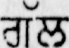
ਗੱਲ
